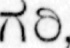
ಗರಿ,
